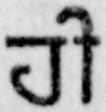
ਹੀ
